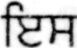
ਇਸ
